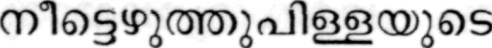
നീട്ടെഴുത്തുപിള്ളയുടെ
